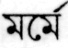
মর্মে
